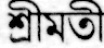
শ্রীমতী
